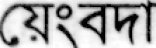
য়েংবদা
